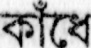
কাঁধে
